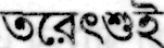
তরেৎশুই
